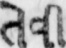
તેવી
